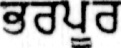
ਭਰਪੂਰ
